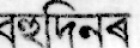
বহুদিনৰ
